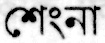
শেংনা
